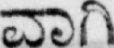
ವಾಗಿ
